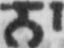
ਨਾ
